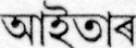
আইতাৰ
